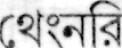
থেংনরি
